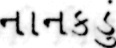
નાનકડું
